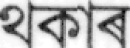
থকাৰ
